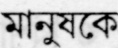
মানুষকে
